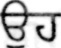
ਉਹ
